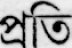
প্রতি
